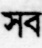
সব
